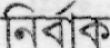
নির্বাক
